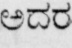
ಅದರ
